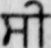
ਸੀ
